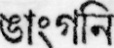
ঙাংগনি
